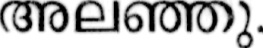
അലഞ്ഞു.
